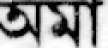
অমা
